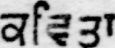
ਕਵਿਤਾ
